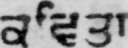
ਕਵਿਤਾ
